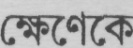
ক্ষেণেকে
